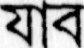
যাব
